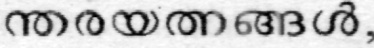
ന്തരയത്നങ്ങള്‍,
